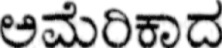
ಅಮೆರಿಕಾದ
